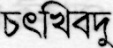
চৎখিবদু
